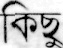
কিছু
